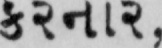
કરનાર,
